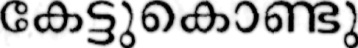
കേട്ടുകൊണ്ടു
